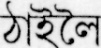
ঠাইলৈ
